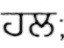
ਹਲ;
